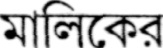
মালিকের
